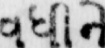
વધીને
